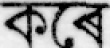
কৰে
